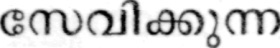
സേവിക്കുന്ന
